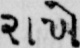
રાખે
